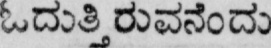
ಓದುತ್ತಿರುವನೆಂದು
